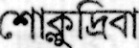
শোক্লুদ্রিবা
